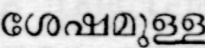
ശേഷമുള്ള
